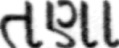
તણા
